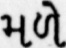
મળે
